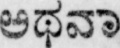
ಅಥವಾ
